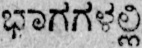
ಭಾಗಗಳಲ್ಲಿ
